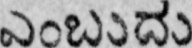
ಎಂಬುದು
